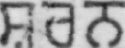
ਸ਼ਰਨ
